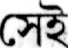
সেই
